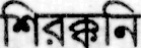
শিরক্কনি
